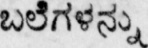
ಬಲೆಗಳನ್ನು
